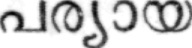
പര്യായ
